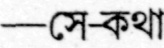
–সে-কথা
